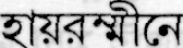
হায়রম্মীনে
